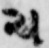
ચ
